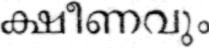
ക്ഷീണവും
